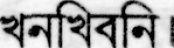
খনখিবনি।
